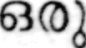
ഒരു
